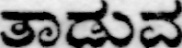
ತಾಡುವ
